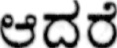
ಆದರೆ
